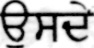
ਉਸਦੇ
